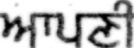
ਆਪਣੀ
